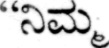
"ನಿಮ್ಮ
